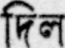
দিল
